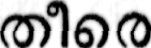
തീരെ
